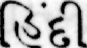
હિંદી
